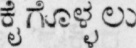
ಕೈಗೊಳ್ಳಲು
